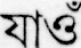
যাওঁ
